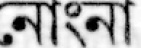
নোংনা
